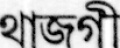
থাজগী
